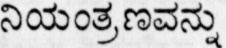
ನಿಯಂತ್ರಣವನ್ನು
